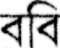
ববি
